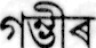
গম্ভীৰ
